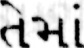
તેમાં
